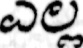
ಎಲ್ಲ
